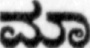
ಮಾ
